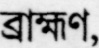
ব্রাহ্মণ,
